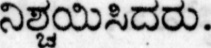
ನಿಶ್ಚಯಿಸಿದರು.
